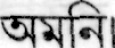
অমনি।
